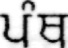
ਪੰਥ
